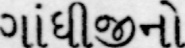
ગાંધીજીનો
